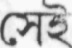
সেই
